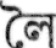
লৈ
